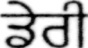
ਡੇਰੀ
